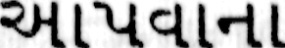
આપવાના
